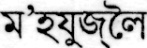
ম'হযুজ্লৈ
